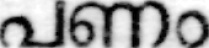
പണം
